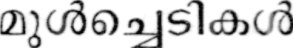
മുള്‍ച്ചെടികള്‍
